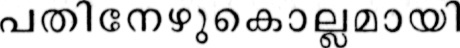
പതിനേഴുകൊല്ലമായി
